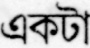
একটা
